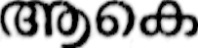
ആകെ
